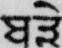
ਬੜੇ
